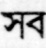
সব
